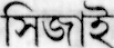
সিজাই
